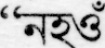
"নহওঁ
